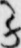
કે
